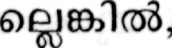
ല്ലെങ്കില്‍,
